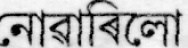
নোৱাৰিলো
